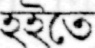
হইতে
